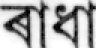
ৰাধা
